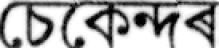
চেকেন্দৰ
